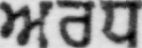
ਅਰਧ
